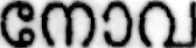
നോവ
